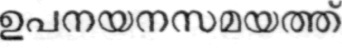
ഉപനയനസമയത്ത്
